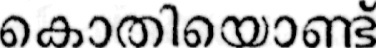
കൊതിയൊണ്ട്
